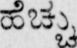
ಹೆಚ್ಚು
